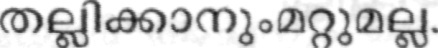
തല്ലിക്കാനുംമറ്റുമല്ല.
